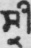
ਸ੍ਰੀ
